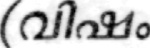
(വിഷം
